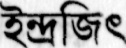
ইন্দ্রজিৎ
